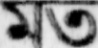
মত
